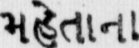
મહેતાના
